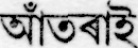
আঁতৰাই
